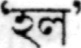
‘হল’
